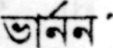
ভার্নন
